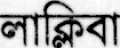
লাক্লিবা
